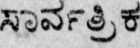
ಸಾರ್ವತ್ರಿಕ
